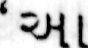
'આ
